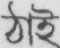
ঠাই
